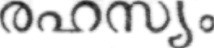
രഹസ്യം
